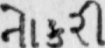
નોકરી
